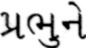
પ્રભુને
